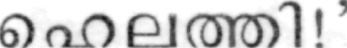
ഹെലത്തി!'
